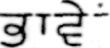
ਭਾਵੇਂ
